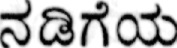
ನಡಿಗೆಯ
